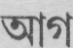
আগ
